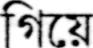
গিয়ে
